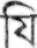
যি
